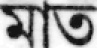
মাত
